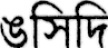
ঙসিদি
